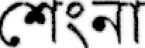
শেংনা
